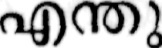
എന്തു
